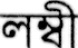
লম্বী
